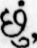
છું,
